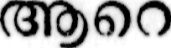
ആറെ
